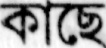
কাছে
